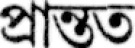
প্রান্তত
